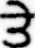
ਤੇ
